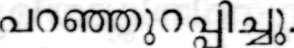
പറഞ്ഞുറപ്പിച്ചു.
